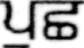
ਪੁਛ
